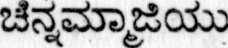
ಚೆನ್ನಮ್ಮಾಜಿಯು
